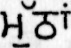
ਮੁੱਠਾਂ
